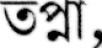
তপ্না,
